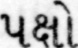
પક્ષો
